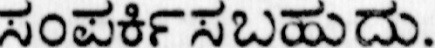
ಸಂಪರ್ಕಿಸಬಹುದು.
